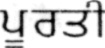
ਪੂਰਤੀ
